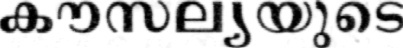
കൌസല്യയുടെ
